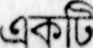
একটি
